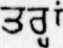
ਤਰ੍ਹਾਂ
